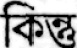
কিন্তু
